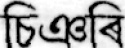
চিঞৰি
